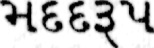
મદદરૂપ
